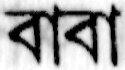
বাবা
